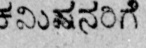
ಕಮಿಷನರಿಗೆ
